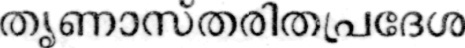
തൃണാസ്തരിതപ്രദേശ
